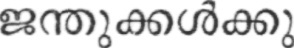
ജന്തുക്കള്‍ക്കു
